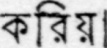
করিয়া
